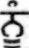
ਨੂੰ
